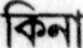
কিনা
